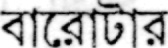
বারোটার
